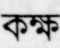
কক্ষ
